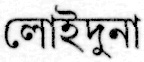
লোইদুনা
